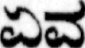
ಏವ
